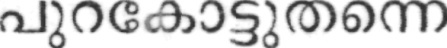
പുറകോട്ടുതന്നെ
